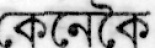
কেনেকৈ
